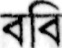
ববি
